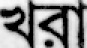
খরা
